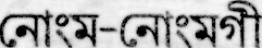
নোংম-নোংমগী
